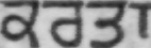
ਕਰਤਾ
